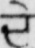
ਦੇ
